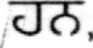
ਹਨ,
